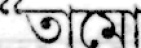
“তামো
